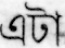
এটা
